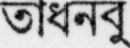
তাধনবু
